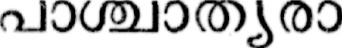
പാശ്ചാത്യരാ
